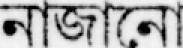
নাজানো
